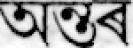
অন্তৰ
